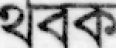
থবক
